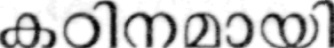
കഠിനമായി
